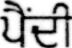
ਪੈਂਦੀ
